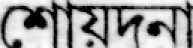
শোয়দনা
